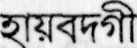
হায়বদগী
